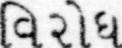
વિરોધ
